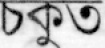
চকুত
